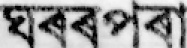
ঘৰৰপৰা
